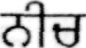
ਨੀਚ
